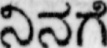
ನಿನಗೆ
